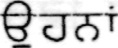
ਉਹਨਾਂ
